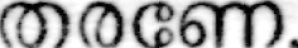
തരണേ.
